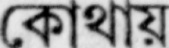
কোথায়
